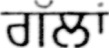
ਗੱਲਾਂ
